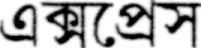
এক্সপ্রেস
